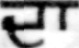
ਦਾ
